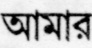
আমার
